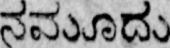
ನಮೂದು
